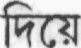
দিয়ে
